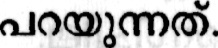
പറയുന്നത്.
